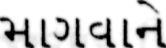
માગવાને
